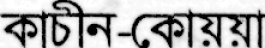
কাচীন-কোয়য়া
